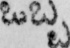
ಒಬ್ಬ
